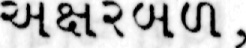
અક્ષરબળ,
